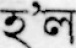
হ'ল
